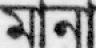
মানা
